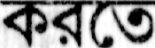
করতে
